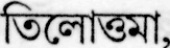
তিলোত্তমা,
